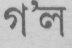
গ'ল
